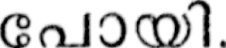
പോയി.
